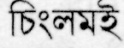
চিংলমই
